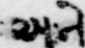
અને
